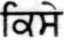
ਕਿਸੇ
